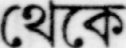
থেকে
